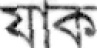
যাক
